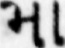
મા
